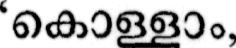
‘കൊള്ളാം,
